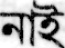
নাই
